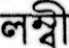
লম্বী
